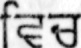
ਵਿਚ
